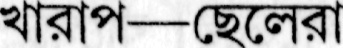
খারাপ–ছেলেরা
